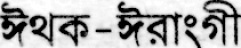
ঈথক-ঈরাংগী
